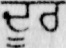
ਦੂਰ
